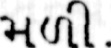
મળી.
